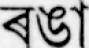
ৰঙা
